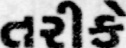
તરીકે
